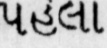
પહેલાં
